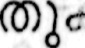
തും
